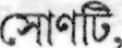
সোণটি,
